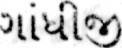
ગાંધીજી
